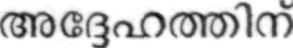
അദ്ദേഹത്തിന്
